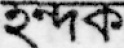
হন্দক
